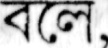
বলে,
